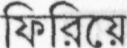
ফিরিয়ে
